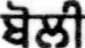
ਬੋਲੀ
